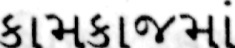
કામકાજમાં
